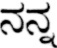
ನನ್ನ
